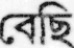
বেছি
